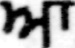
ਆ
